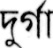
দুর্গা
